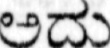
ಅದು
